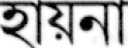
হায়না
